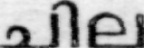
ചില
